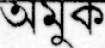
অমুক
